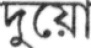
দুয়ো
